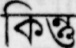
কিন্তু
